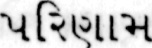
પરિણામ
